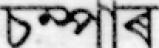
চম্পাৰ
